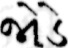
જોડે
